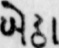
બેઠા
